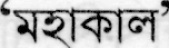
‘মহাকাল’
